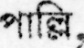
পাল্লি,
